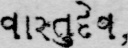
વાસ્તુદેવ,
